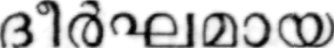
ദീര്‍ഘമായ
